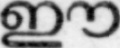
ഈ
